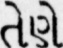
તેણે
